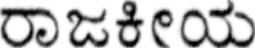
ರಾಜಕೀಯ
